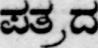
ಪತ್ರದ
